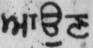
ਆਉਣ
